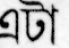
এটা
